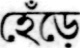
হেঁড়ে
